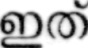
ഇത്
